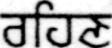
ਰਹਿਣ
